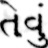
તેવું
